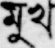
মুখ
